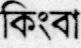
কিংবা
